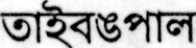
তাইবঙপাল
